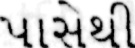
પાસેથી
